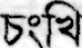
চংখি
